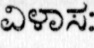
ವಿಳಾಸ:
